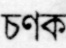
চণক
